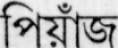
পিয়াঁজ
